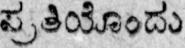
ಪ್ರತಿಯೊಂದು
